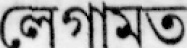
লেগামত
